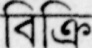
বিক্রি
